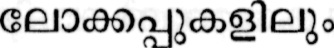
ലോക്കപ്പുകളിലും
